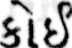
કોઈ
